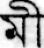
মী
